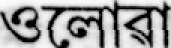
ওলোৱা
